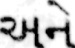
અને
